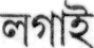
লগাই
